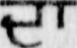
ਦਾ
